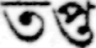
তপ্ত
